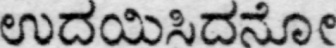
ಉದಯಿಸಿದನೋ
